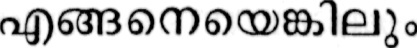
എങ്ങനെയെങ്കിലും
